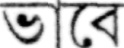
ভাবে
